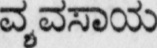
ವ್ಯವಸಾಯ
